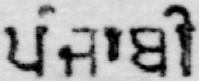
ਪੰਜਾਬੀ
